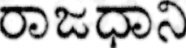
ರಾಜಧಾನಿ
